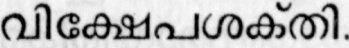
വിക്ഷേപശക്തി.
